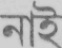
নাই
